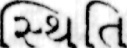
સ્થિતિ
